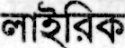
লাইরিক
